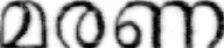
മരണ
